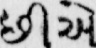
છીએ
